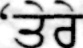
'ਤੇਰੇ
